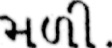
મળી.
